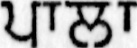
ਪਾਲਾ
